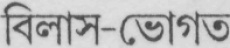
বিলাস-ভোগত
